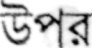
উপর
